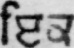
ਇਕ
